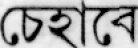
চেহাবে
